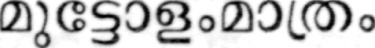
മുട്ടോളംമാത്രം
